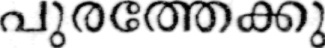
പുരത്തേക്കു
